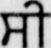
ਸੀ
